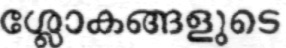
ശ്ലോകങ്ങളുടെ
